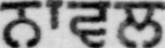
ਨਾਵਲ
